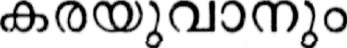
കരയുവാനും
